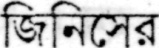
জিনিসের
